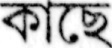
কাছে
